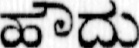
ಹೌದು
